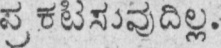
ಪ್ರಕಟಿಸುವುದಿಲ್ಲ.
